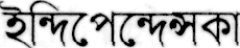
ইন্দিপেন্দেন্সকা
